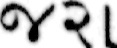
જરા
